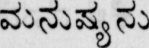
ಮನುಷ್ಯನು
